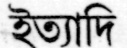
ইত্যাদি
